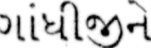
ગાંધીજીને
